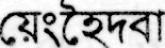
য়েংহৈদবা
